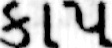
કાપ
